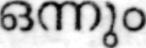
ഒന്നും
